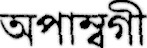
অপাম্বগী
